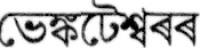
ভেঙ্কটেশ্বৰৰ
